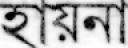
হায়না
